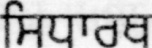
ਸਿਧਾਰਥ
